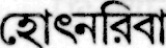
হোৎনরিবা
